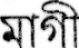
মাগী
